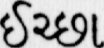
ઇચ્છા
